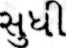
સુધી
